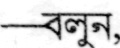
–বলুন,
